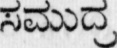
ಸಮುದ್ರ
